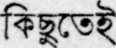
কিছুতেই
